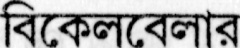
বিকেলবেলার
